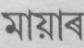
মায়াৰ
